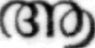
ആ
